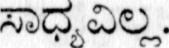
ಸಾಧ್ಯವಿಲ್ಲ.
